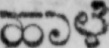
ಹಾಳೆ
